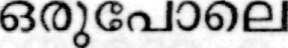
ഒരുപോലെ
